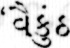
'વૈકુંઠ
